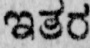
ಇತರ
